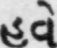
હવે
